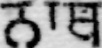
ਨਾਥ
